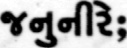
જનુનીરે;
